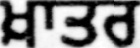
ਖ਼ਾਤਰ
